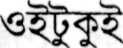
ওইটুকুই
